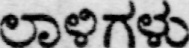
ಲಾಳಿಗಳು
